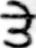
ਤੇ
